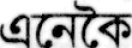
এনেকৈ
